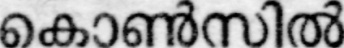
കൊണ്‍സില്‍
